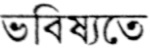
ভবিষ্যতে
